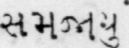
સમજાયું
